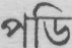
পড়ি
